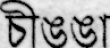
চীঙঙা
